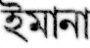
ইমানা
